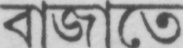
বাজাতে
